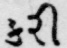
કરી
